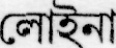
লোইনা
